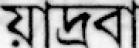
য়াদ্রবা
